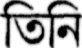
তিনি
